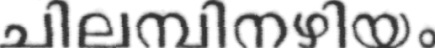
ചിലമ്പിനഴിയം
